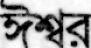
ঈশ্বর
